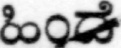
ಹಿಂದೆ
